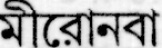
মীরোনবা
